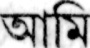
আমি
